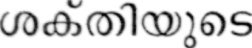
ശക്തിയുടെ
